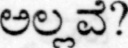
ಅಲ್ಲವೆ?
